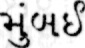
મુંબઈ
